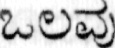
ಒಲವು
